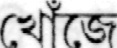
খোঁজে
